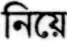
নিয়ে
